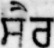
ਸੈਰ
